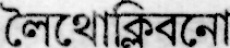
লৈথোক্লিবনো
